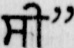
ਸੀ''
